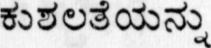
ಕುಶಲತೆಯನ್ನು
